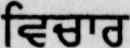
ਵਿਚਾਰ
